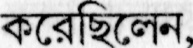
করেছিলেন,
